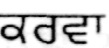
ਕਰਵਾ
